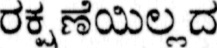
ರಕ್ಷಣೆಯಿಲ್ಲದ
